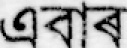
এবাৰ
